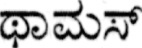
ಥಾಮಸ್
